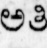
ಅತಿ
